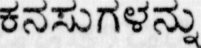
ಕನಸುಗಳನ್ನು
